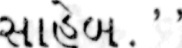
સાહેબ."
